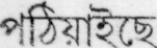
পঠিয়াইছে
